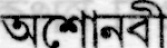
অশোনবী
